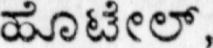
ಹೊಟೇಲ್,
